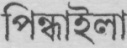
পিন্ধাইলা
